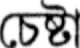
চেষ্টা
